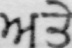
ਅਤੇ
